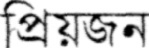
প্রিয়জন
